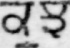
ਕੁਝ
